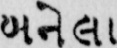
બનેલા
